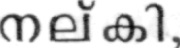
നല്കി,
